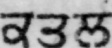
ਕਤਲ
